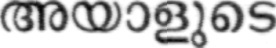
അയാളുടെ
